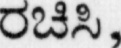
ರಚಿಸಿ,
